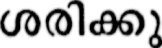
ശരിക്കു
